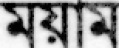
ময়াম
